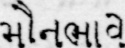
મૌનભાવે
